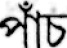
পাঁচ
